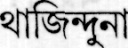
থাজিন্দুনা
